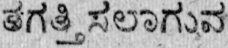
ತಗತ್ತಿಸಲಾಗುವ
